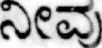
ನೀವು
